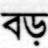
বড়
